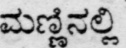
ಮಣ್ಣಿನಲ್ಲಿ
